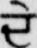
ਦੇ
